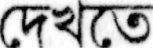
দেখতে
